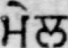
ਮੇਲ
